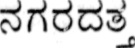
ನಗರದತ್ತ
